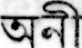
অনী
